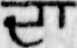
ਦਾ
